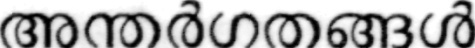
അന്തര്‍ഗതങ്ങള്‍
